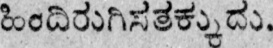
ಹಿಂದಿರುಗಿಸತಕ್ಕುದು.
